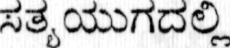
ಸತ್ಯಯುಗದಲ್ಲಿ
